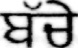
ਬੱਚੇ
